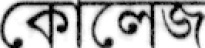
কোলেজ
